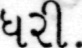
ધરી.
